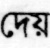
দেয়
